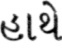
હાથે
